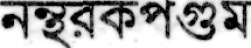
নন্থরকপগুম
